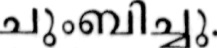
ചുംബിച്ചു.
